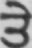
ਤੇ
